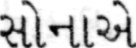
સોનાએ
